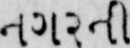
નગરની
